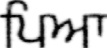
ਪਿਆ
